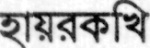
হায়রকখি
